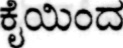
ಕೈಯಿಂದ
